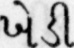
ખેડી
